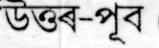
উত্তৰ-পূব
